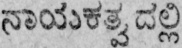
ನಾಯಕತ್ವದಲ್ಲಿ
